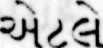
એટલે
